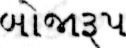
બોજારૂપ
